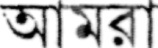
আমরা
